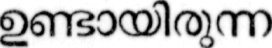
ഉണ്ടായിരുന്ന
